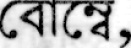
বোম্বে,
